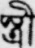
স্ত্রী
